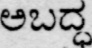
ಅಬದ್ಧ
